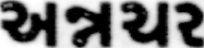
અન્નચર
